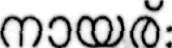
നായര്:
